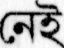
নেই
